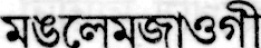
মঙলেমজাওগী
